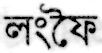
লংফৈ
